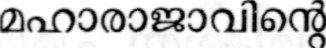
മഹാരാജാവിന്റെ
